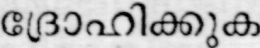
ദ്രോഹിക്കുക
